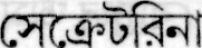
সেক্রেটরিনা
